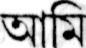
আমি
